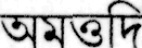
অমত্তদি
